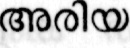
അരിയ
